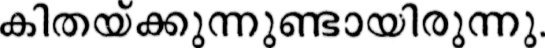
കിതയ്ക്കുന്നുണ്ടായിരുന്നു.
